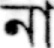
না
